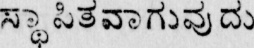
ಸ್ಥಾಪಿತವಾಗುವುದು
